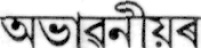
অভাৱনীয়ৰ
